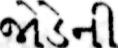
જોડેની
